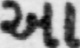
આ
